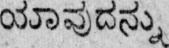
ಯಾವುದನ್ನು
